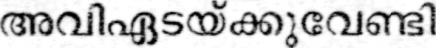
അവിഏടയ്ക്കുവേണ്ടി
